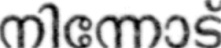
നിന്നോട്
